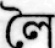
লৈ
